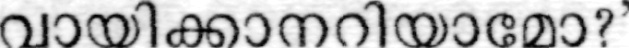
വായിക്കാനറിയാമോ?’
